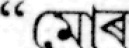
"মোৰ
